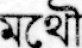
মথৌ
